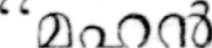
"മഹന്‍
